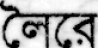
লৈরে
